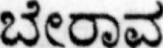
ಬೇರಾವ
